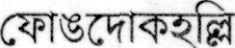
ফোঙদোকহল্লি
